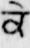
ਕੇ
